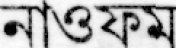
নাওফম
